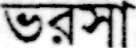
ভরসা
